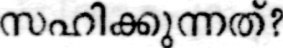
സഹിക്കുന്നത്?
